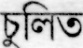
চুলিত
